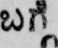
ಬಗ್ಗೆ
